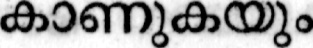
കാണുകയും
